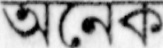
অনেক
